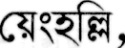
য়েংহল্লি,
